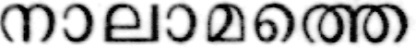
നാലാമത്തെ
